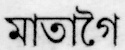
মাতাগৈ
